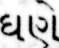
ઘણે
